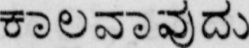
ಕಾಲವಾವುದು
